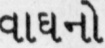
વાઘનો
